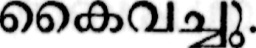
കൈവച്ചു.
